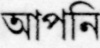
আপনি
